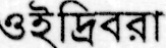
ওইদ্রিবরা
